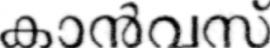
കാന്‍വസ്
